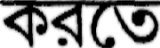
করতে
